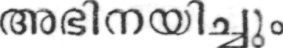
അഭിനയിച്ചും
